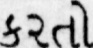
કરતો
